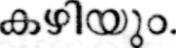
കഴിയും.
